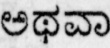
ಅಥವಾ
